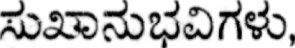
ಸುಖಾನುಭವಿಗಳು,
